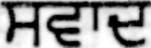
ਸਵਾਦ
